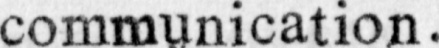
communication.
